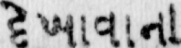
દેખાવાના
